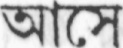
আসে
